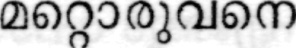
മറ്റൊരുവനെ
